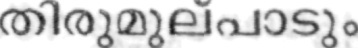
തിരുമുല്പാടും
